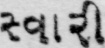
સ્વારી
